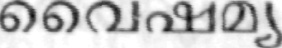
വൈഷമ്യ
